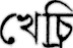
খেচ্রি
